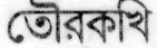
তৌরকখি
